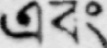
এবং
